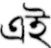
এই
